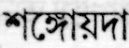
শঙ্গোয়দা
